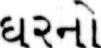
ઘરનો
